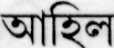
আহিল
